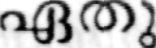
ഏതു
